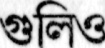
গুলিও
